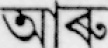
আৰু
